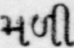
મળી
